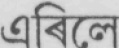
এৰিলে
